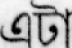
এটা
